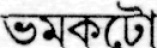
ভমকটো
